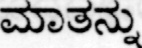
ಮಾತನ್ನು
